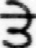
ਤੇ
